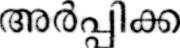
അര്‍പ്പിക്ക
